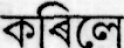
কৰিলে
